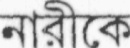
নারীকে
